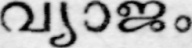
വ്യാജം
